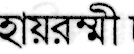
হায়রম্মী
